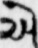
એ
